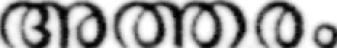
അത്തരം
